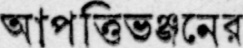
আপত্তিভঞ্জনের
